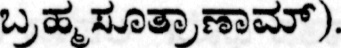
ಬ್ರಹ್ಮಸೂತ್ರಾಣಾಮ್).
